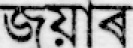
জয়াৰ
